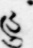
હું
